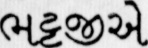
ભટ્ટજીએ
